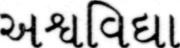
અશ્વવિદ્યા
